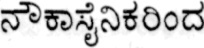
ನೌಕಾಸೈನಿಕರಿಂದ
